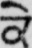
ਕੇ
